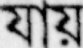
যায়
